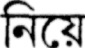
নিয়ে
